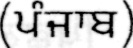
(ਪੰਜਾਬ)
